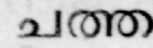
ചത്ത
